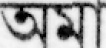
অমা
